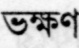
ভক্ষণ
